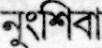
নুংশিবা
